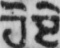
ਹੋਏ
